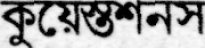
কুয়েস্তশনস
